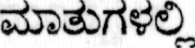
ಮಾತುಗಳಲ್ಲಿ
